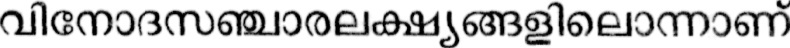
വിനോദസഞ്ചാരലക്ഷ്യങ്ങളിലൊന്നാണ്
